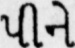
પીને
